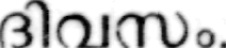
ദിവസം.
